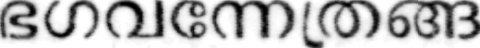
ഭഗവന്നേത്രങ്ങ
